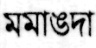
মমাঙদা
